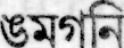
ঙমগনি
